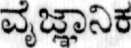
ವೈಜ್ಞಾನಿಕ
